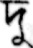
দু
